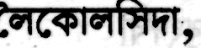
লৈকোলসিদা,
